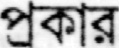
প্রকার
